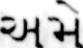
અમે
